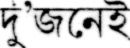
দু’জনেই
